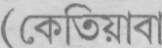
(কেতিয়াবা
